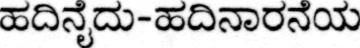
ಹದಿನೈದು-ಹದಿನಾರನೆಯ
